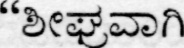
“ಶೀಘ್ರವಾಗಿ
